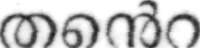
തന്റെ
